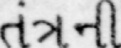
તંત્રની
